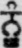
ਨੂੰ
